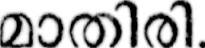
മാതിരി.
